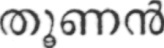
തൂണന്‍
